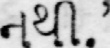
નથી.'
